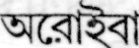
অরোইবা
